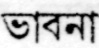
ভাবনা
